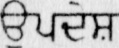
ਉਪਦੇਸ਼
